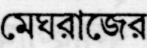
মেঘরাজের
